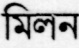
মিলন
